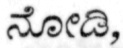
ನೋಡಿ,
